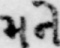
મને
